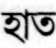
হাত
